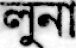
লুনা
